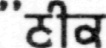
''ਠੀਕ
